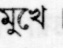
মুখে
